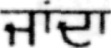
ਜਾਂਦਾ
